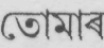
তোমাৰ
